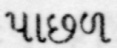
પાછળ
